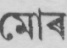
মোৰ
